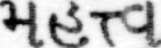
મહત્વ
